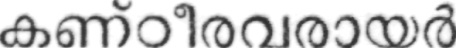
കണ്ഠീരവരായര്‍
